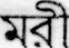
মরী
